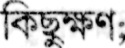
কিছুক্ষণ;
